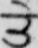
ਤੇ
